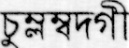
চুম্লম্বদগী
